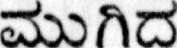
ಮುಗಿದ
